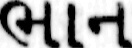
ભાન
